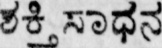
ಶಕ್ತಿಸಾಧನ
